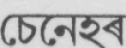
চেনেহৰ
